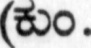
(ಕುಂ.
